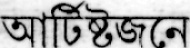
আৰ্টিষ্টজনে
